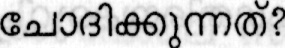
ചോദിക്കുന്നത്?
